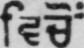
ਵਿਚੋਂ
